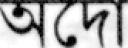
অদো
